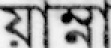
য়াম্না
